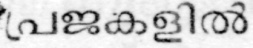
പ്രജകളില്‍
